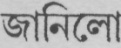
জানিলো
